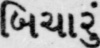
બિચારું
